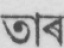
তাৰ
